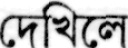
দেখিলে
